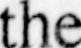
the
